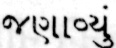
જણાવ્યું
